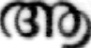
ആ
